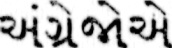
અંગ્રેજોએ
